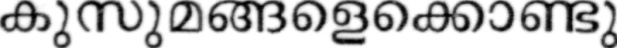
കുസുമങ്ങളെക്കൊണ്ടു
